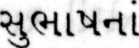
સુભાષનાં
